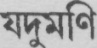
যদুমণি
